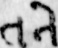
તને
